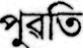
পুৱতি
